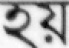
হয়
